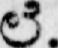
ಲೆ.
